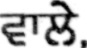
ਵਾਲੇ,
